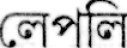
লেপলি
